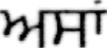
ਅਸਾਂ
